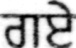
ਗਏ
